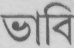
ভাবি
